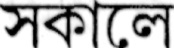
সকালে
